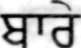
ਬਾਰੇ
